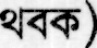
থবক)
